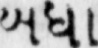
બધા
